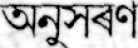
অনুসৰণ
